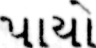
પાયો
